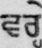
ਵਰ੍ਹੇ
